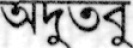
অদুতবু
